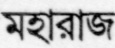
মহারাজ
